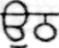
ਉਠ
